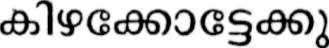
കിഴക്കോട്ടേക്കു
